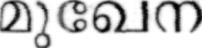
മുഖേന
